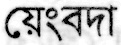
য়েংবদা
